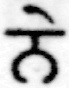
ਨੇ
